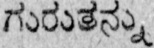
ಗುರುತನ್ನು
